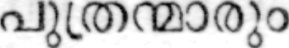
പുത്രന്മാരും
